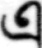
এ
